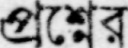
প্রশ্নের
